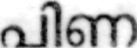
പിണ
